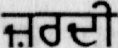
ਜ਼ਰਦੀ
